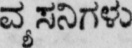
ವ್ಯಸನಿಗಳು
